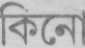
কিনো
